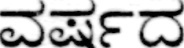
ವರ್ಷದ
